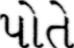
પોતે
